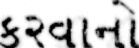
કરવાનો
